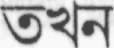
তখন
